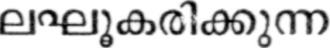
ലഘൂകരിക്കുന്ന
